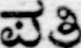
ಪತಿ
